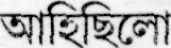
আহিছিলো
